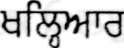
ਖਲ੍ਹਿਆਰ
